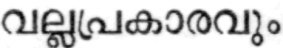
വല്ലപ്രകാരവും
